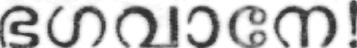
ഭഗവാനേ!
